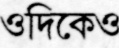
ওদিকেও
